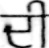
ਦੀ
